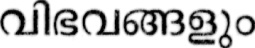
വിഭവങ്ങളും
